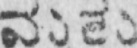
ಮತ್ತು
